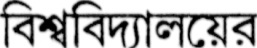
বিশ্ববিদ্যালয়ের
